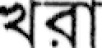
খরা
